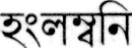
হংলম্বনি
